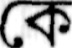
কে
